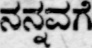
ನನ್ನವಗೆ
